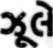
ઝૂલે
